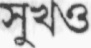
সুখও
